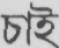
চাই
